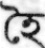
হৈ
